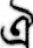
ঐ
